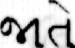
જાતે
